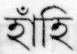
হাঁহি
